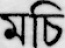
মচি
